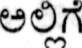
ಅಲ್ಲಿಗೆ
